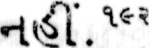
નહીં.૧૯૨
